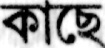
কাছে
